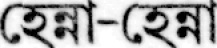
হেন্না-হেন্না
